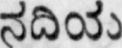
ನದಿಯ
